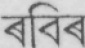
ৰবিৰ
